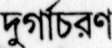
দুর্গাচরণ
